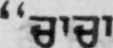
''ਚਾਚਾ
